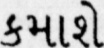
કમાશે
